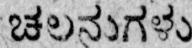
ಚಲನುಗಳು
